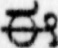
ಈ
